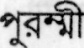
পুরম্মী
